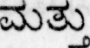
ಮತ್ತು
